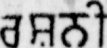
ਰਸ਼ਨੀ
